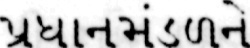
પ્રધાનમંડળને
